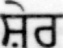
ਸ਼ੇਰ
